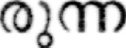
രുന്ന
